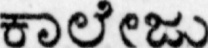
ಕಾಲೇಜು
